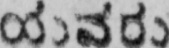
ಯವರು
